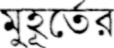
মুহূর্তের
